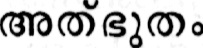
അത്ഭുതം
